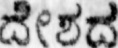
ದೇಶದ
